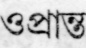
ওপ্রান্ত
